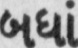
બધાં
